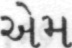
એમ
